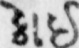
કોઈ
